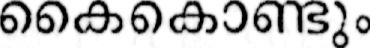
കൈകൊണ്ടും
